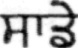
ਸਾਡੇ
